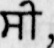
ਸੀ,
